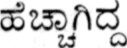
ಹೆಚ್ಚಾಗಿದ್ದ
